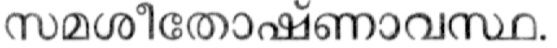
സമശീതോഷ്ണാവസ്ഥ.
